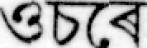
ওচৰে
